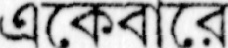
একেবারে
